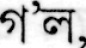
গ'ল,
